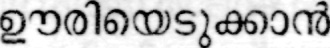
ഊരിയെടുക്കാന്‍
